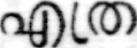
എത്ര
